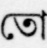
তো
